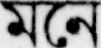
মনে
